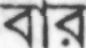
বার
